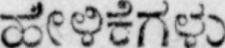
ಹೇಳಿಕೆಗಳು
